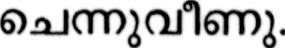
ചെന്നുവീണു.
